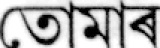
তোমাৰ
